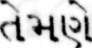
તેમણે
